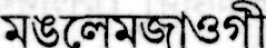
মঙলেমজাওগী
